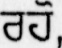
ਰਹੋ,
